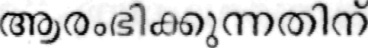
ആരംഭിക്കുന്നതിന്
